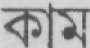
কাম
